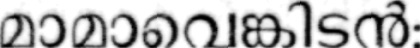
മാമാവെങ്കിടന്‍:
